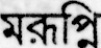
মরূপ্নি
